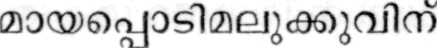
മായപ്പൊടിമലുക്കുവിന്
